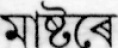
মাষ্টৰে
